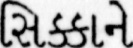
સિક્કાને
